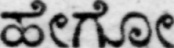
ಹೇಗೋ
